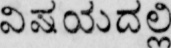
ವಿಷಯದಲ್ಲಿ
